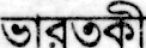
ভারতকী
